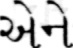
એને
